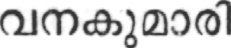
വനകുമാരി
